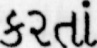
કરતાં
